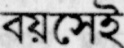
বয়সেই
